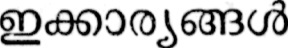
ഇക്കാര്യങ്ങള്‍
